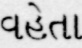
વહેતા
